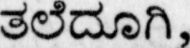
ತಲೆದೂಗಿ,
